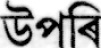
উপৰি
